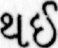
થઈ
